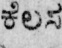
ಕೆಲಸ
